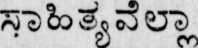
ಸಾಹಿತ್ಯವೆಲ್ಲಾ
